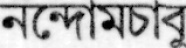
নন্দোমচাবু
